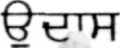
ਉਦਾਸ
